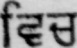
ਵਿਚ
